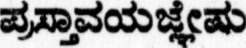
ಪ್ರಸ್ತಾವಯಜ್ಞೇಷು
